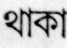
থাকা
